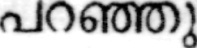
പറഞ്ഞു
